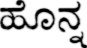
ಹೊನ್ನ
